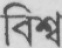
বিশ্ব
